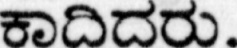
ಕಾದಿದರು.
